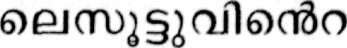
ലെസൂട്ടുവിന്റെ
